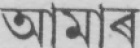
আমাৰ
